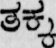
ತಕ್ಕ
